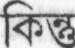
কিন্তু
